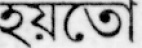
হয়তো
